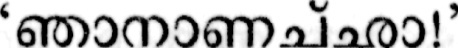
‘ഞാനാണച്ഛാ!’
